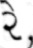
રે,
